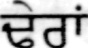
ਢੇਰਾਂ
